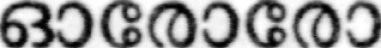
ഓരോരോ
